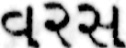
વરસ
